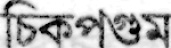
চিকপগুম
